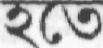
হতে
